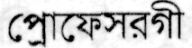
প্রোফেসরগী
